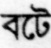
বটে
